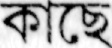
কাছে
